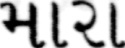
મારા
